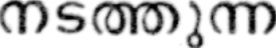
നടത്തുന്ന
